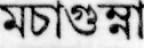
মচাগুম্না
